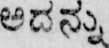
ಅದನ್ನು
